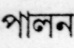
পালন
